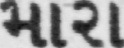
મારા
